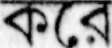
করে
